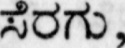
ಸೆರಗು,
